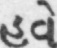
હવે
